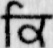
ਕਿ
